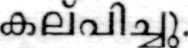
കല്പിച്ചു.
